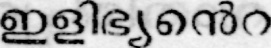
ഇളിഭ്യന്റെ
